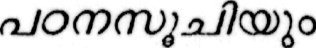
പഠനസൂചിയും
